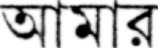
আমার
